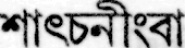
শাৎচনীংবা
